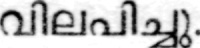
വിലപിച്ചു.
